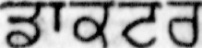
ਡਾਕਟਰ
